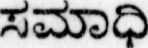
ಸಮಾಧಿ
